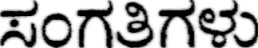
ಸಂಗತಿಗಳು
